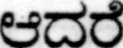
ಆದರೆ
